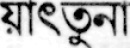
য়াৎতুনা
